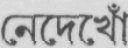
নেদেখোঁ
